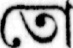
তো
